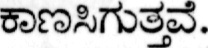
ಕಾಣಸಿಗುತ್ತವೆ.
